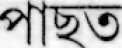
পাছত
